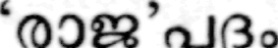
'രാജ'പദം
